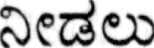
ನೀಡಲು
